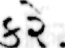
કરે.
